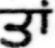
ਤਾਂ
